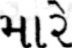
મારે
